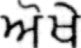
ਅੋਖੇ
